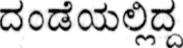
ದಂಡೆಯಲ್ಲಿದ್ದ
